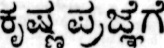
ಕೃಷ್ಣಪ್ರಜ್ಞೆಗೆ
